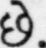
છે.
